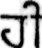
ਹੀ
